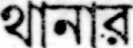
থানার
